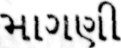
માગણી
